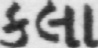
કલા
